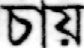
চায়
